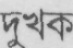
দুখক
